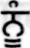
ਨੂੰ
